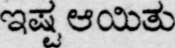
ಇಷ್ಟಆಯಿತು
